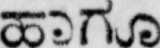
ಹಾಗೂ
